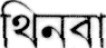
থিনবা
